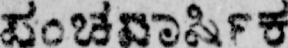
ಪಂಚವಾರ್ಷಿಕ
